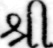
શ્રી
